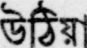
উঠিয়া
